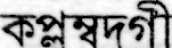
কপ্লম্বদগী
